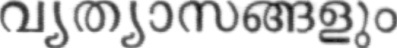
വ്യത്യാസങ്ങളും
